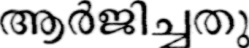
ആര്‍ജിച്ചതു
